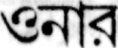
ওনার
